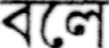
বলে
